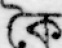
কৈ
